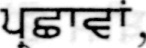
ਪ੍ਰਛਾਵਾਂ,
